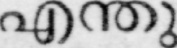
എന്തു
